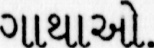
ગાથાઓ.
